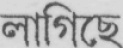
লাগিছে
